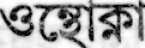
ওন্থোক্না
